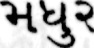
મધુર
